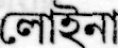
লোইনা
